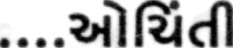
.........ઓચિંતી
